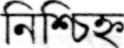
নিশ্চিহ্ন
